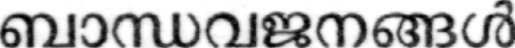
ബാന്ധവജനങ്ങള്‍
